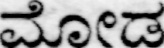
ಮೋಡ
